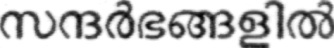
സന്ദര്‍ഭങ്ങളില്‍
